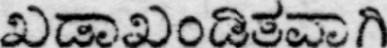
ಖಡಾಖಂಡಿತವಾಗಿ
